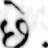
છે.
